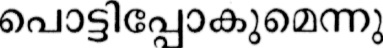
പൊട്ടിപ്പോകുമെന്നു
